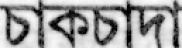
চাকচাদা
